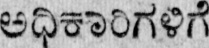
ಅಧಿಕಾರಿಗಳಿಗೆ
